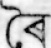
ৰৈ
